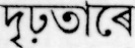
দৃঢ়তাৰে
